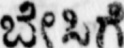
ಬೇಸಿಗೆ
